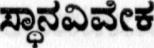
ಸ್ಥಾನವಿವೇಕ
